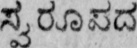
ಸ್ವರೂಪದ
